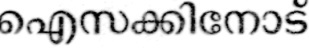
ഐസക്കിനോട്
